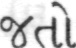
જતો
